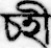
চহী
